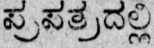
ಪ್ರಪತ್ರದಲ್ಲಿ
